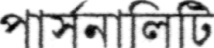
পার্সনালিটি
